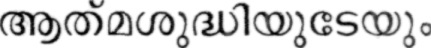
ആത്മശുദ്ധിയുടേയും
